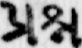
પ્રશ્ન
